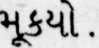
મૂકયો.
